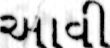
આવી
